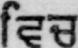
ਵਿਚ
